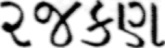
રજકણ
